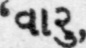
'વારુ,
